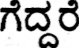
ಗೆದ್ದರೆ
